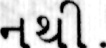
નથી.
